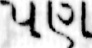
પણ
